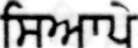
ਸਿਆਪੇ
